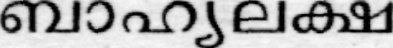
ബാഹ്യലക്ഷ
